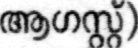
ആഗസ്റ്റ്)
